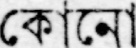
কোনো
